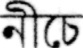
নীচে
